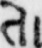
તો
